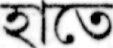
হাতে
